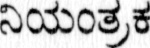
ನಿಯಂತ್ರಕ
